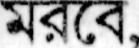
মরবে,
